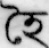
হৈ
